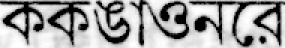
ককঙাওনরে
